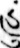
હું
